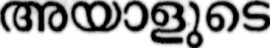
അയാളുടെ
